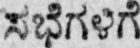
ಸಭೆಗಳಿಗೆ
